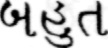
બહુત
